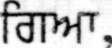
ਗਿਆ,
